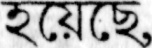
হয়েছে,
